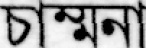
চাম্মনা
